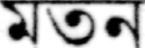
মতন
